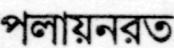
পলায়নরত
